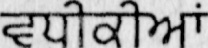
ਵਧੀਕੀਆਂ
